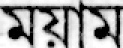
ময়াম
